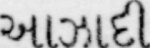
આઝાદી
